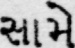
સામે
